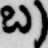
ಬ)
